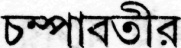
চম্পাবতীর
